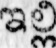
ಇಲ್ಲಿ
